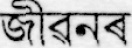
জীৱনৰ
